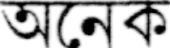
অনেক
